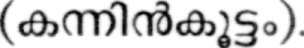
(കന്നിന്‍കൂട്ടം).
